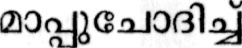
മാപ്പുചോദിച്ച്
